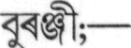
বুৰঞ্জী;-
